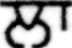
ਲਾ
